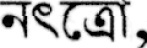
নৎত্রো,
